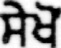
ਸੇਖੋਂ
